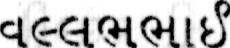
વલ્લભભાઈ
